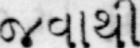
જવાથી
